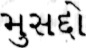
મુસદ્દો
